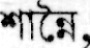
শান্নৈ,
